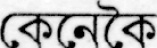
কেনেকৈ
